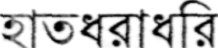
হাতধরাধরি
